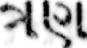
ત્રણ
